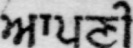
ਆਪਣੀ
